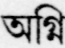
অগ্নি
